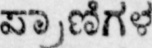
ಪ್ರಾಣಿಗಳ
